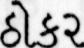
ઠોકર
